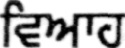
ਵਿਆਹ
